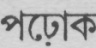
পঢ়োক
